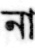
না
